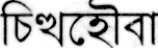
চিত্থহৌবা
